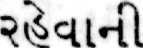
રહેવાની
